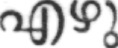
എഴു
